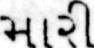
મારી
